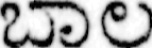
ಬಾಲ
